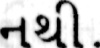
નથી.
